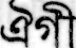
ঐগী
